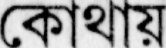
কোথায়
